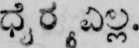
ಧೈರ್‍ಯವಿಲ್ಲ.
